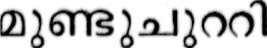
മുണ്ടുചുററി
